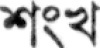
শংখ
